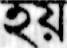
হয়
